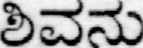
ಶಿವನು
